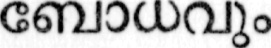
ബോധവും
